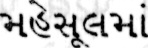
મહેસૂલમાં
